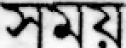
সময়
